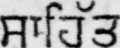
ਸਾਹਿੱਤ
